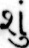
શું
